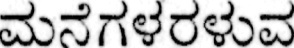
ಮನೆಗಳರಳುವ
